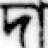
দা
